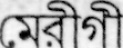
মেরীগী
